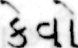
કેવો
